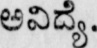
ಅವಿದ್ಯೆ.
